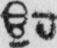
ਉਹ
